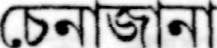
চেনাজানা
